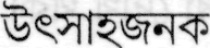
উৎসাহজনক
